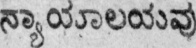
ನ್ಯಾಯಾಲಯವು
